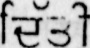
ਦਿੱਤੀ
